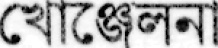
খোঞ্জেলনা
